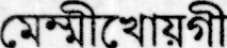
মেম্মীখোয়গী
